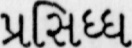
પ્રસિધ્ધ
